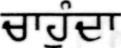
ਚਾਹੁੰਦਾ
